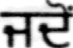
ਜਦੋਂ
